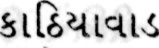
કાઠિયાવાડ
